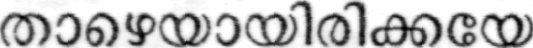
താഴെയായിരിക്കയേ
